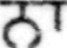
ਨਾ
